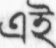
এই
